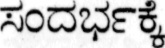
ಸಂದರ್ಭಕ್ಕೆ
